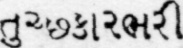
તુચ્છકારભરી
